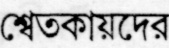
শ্বেতকায়দের
